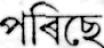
পৰিছে
